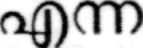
എന്ന
